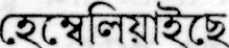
হেম্বেলিয়াইছে
